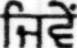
ਜਿਵੇਂ
